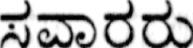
ಸವಾರರು
